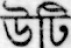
উটি
